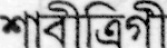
শাবীত্রিগী
